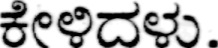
ಕೇಳಿದಳು.
